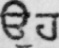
ਉਹ
